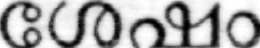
ശേഷം
